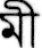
মী
